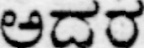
ಅದರ
